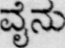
ವೈನು
